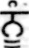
ਨੂੰ
